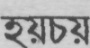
হয়চয়
